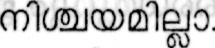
നിശ്ചയമില്ലാ.
